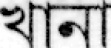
খানা
